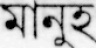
মানুহ
